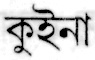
কুইনা
